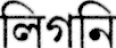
লিগনি
